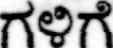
ಗಳಿಗೆ
